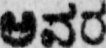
ಅವರ
